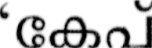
'കേപ്
